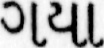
ગયા
